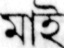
মাই
